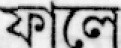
ফালে
